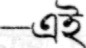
-এই
